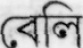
বেলি
